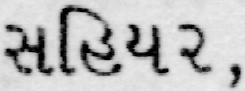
સહિયર,
